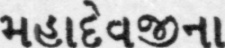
મહાદેવજીના
